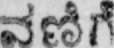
ವಣಿಗೆ
